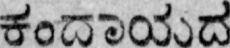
ಕಂದಾಯದ
